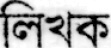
লিখক
